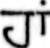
ਹਾਂ
